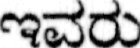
ಇವರು
